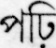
পঢ়ি
